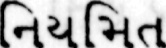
નિયમિત
